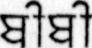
ਬੀਬੀ
